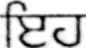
ਇਹ
